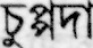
চুপ্পদা
